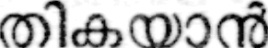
തികയാന്‍
